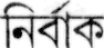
নির্বাক
